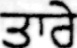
ਤਾਰੇ
